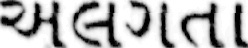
અલગતા
